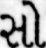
સો
